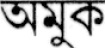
অমুক
